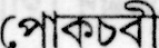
পোকচবী
